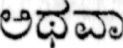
ಅಥವಾ
